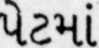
પેટમાં
